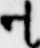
ન
